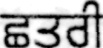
ਛਤਰੀ
